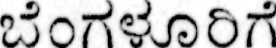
ಬೆಂಗಳೂರಿಗೆ
